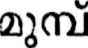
മുമ്പ്
